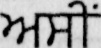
ਅਸੀਂ
